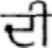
ਦੀ
